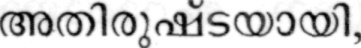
അതിരുഷ്ടയായി,
